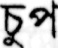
চুপ
